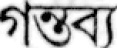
গন্তব্য
